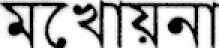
মখোয়না
